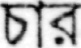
চার
